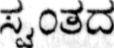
ಸ್ವಂತದ
